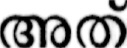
അത്
